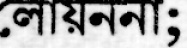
লোয়ননা;
